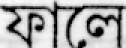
ফালে
